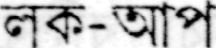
লক-আপ
